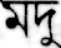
মদু
